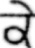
ਕੇ
